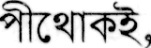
পীথোকই,
